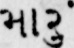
મારું
